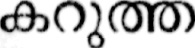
കറുത്ത
